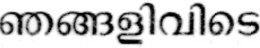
ഞങ്ങളിവിടെ
